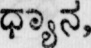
ಧ್ಯಾನ,
